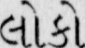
લોકો
